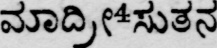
ಮಾದ್ರೀ4ಸುತನ
